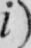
i)
